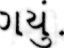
ગયું.
